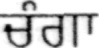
ਚੰਗਾ
